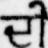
ਦੀ
